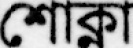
শোক্না
